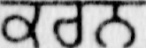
ਕਰਨ
